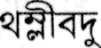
থম্লীবদু
